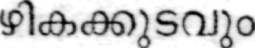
ഴികക്കുടവും
